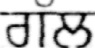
ਗੱਲ
